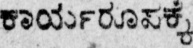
ಕಾರ್ಯರೂಪಕ್ಕೆ
